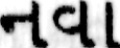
નવા
